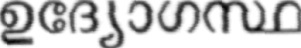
ഉദ്യോഗസ്ഥ
